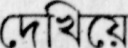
দেখিয়ে
